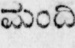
ಮಂದಿ
